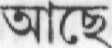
আছে
